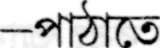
-পাঠাতে
